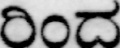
ರಿಂದ
